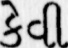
કેવી
